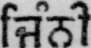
ਜਿੰਨੀ
